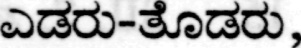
ಎಡರು-ತೊಡರು,
